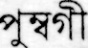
পুম্বগী
